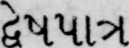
દ્વેષપાત્ર
